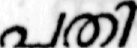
പതി
